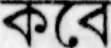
কবে
